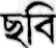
ছবি
